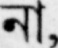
না,
